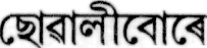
ছোৱালীবোৰে
